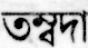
তম্বদা
